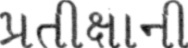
પ્રતીક્ષાની
